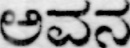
ಅವನ
